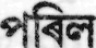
পৰিল
